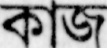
কাজ
